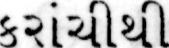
કરાંચીથી
